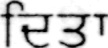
ਦਿਤਾ
